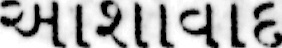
આશાવાદ
